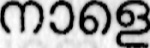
നാളെ
